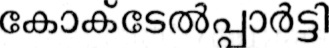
കോക്ടേല്‍പ്പാര്‍ട്ടി
